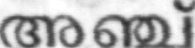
അഞ്ച്
